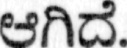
ಆಗಿದೆ.
